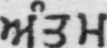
ਅੰਤਮ
